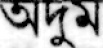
অদুম
